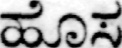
ಹೊಸ
